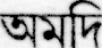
অমদি
